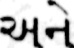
અને
